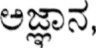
ಅಜ್ಞಾನ,
